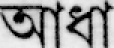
আধা
